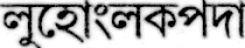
লুহোংলকপদা
